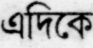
এদিকে
